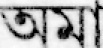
অমা
